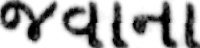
જવાના
